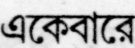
একেবারে
